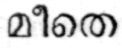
മീതെ
